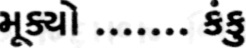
મૂક્યો......કંકુ
